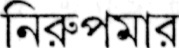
নিরুপমার
